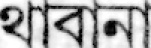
থাবানা
